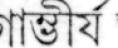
গাম্ভীর্য
